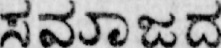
ಸಮಾಜದ
